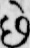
છે
